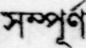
সম্পূর্ণ
